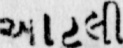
આટલી
